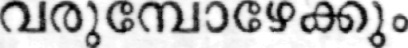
വരുമ്പോഴേക്കും
